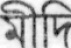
মীদি
